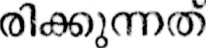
രിക്കുന്നത്
